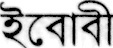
ইবোবী
